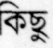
কিছু
